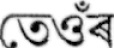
তেওঁৰ
